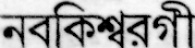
নবকিশ্বরগী
